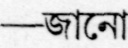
–জানো
